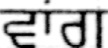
ਵਾਂਗ
